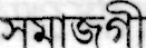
সমাজগী
